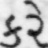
કરે
